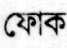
ফোক
